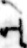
ને
